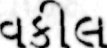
વકીલ
